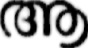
ആ
